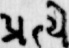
પ્રત્યે
